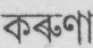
কৰুণা
